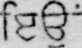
ਇਉਂ
